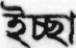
ইচ্ছা
